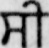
ਸੀ
